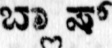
ಬ್ಲಾಷ್
